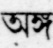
অঙ্গ
